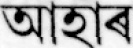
আহাৰ
